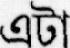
এটা
